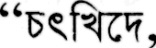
“চৎখিদে,
